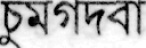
চুমগদবা
